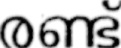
രണ്ട്
